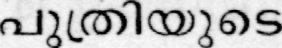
പുത്രിയുടെ
